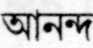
আনন্দ
